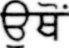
ਉਥੋਂ
